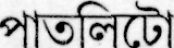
পাতলিটো
